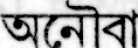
অনৌবা
